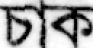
চাক
